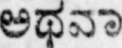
ಅಥವಾ
